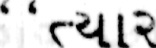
"ત્યાર
